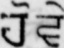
ਹੋਵੇ
